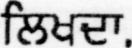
ਲਿਖਦਾ,
